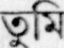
তুমি
